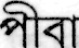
পীবা
